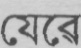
যেৱে
